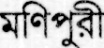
মণিপুরী
